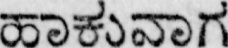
ಹಾಕುವಾಗ
